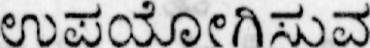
ಉಪಯೋಗಿಸುವ
